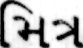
મિત્ર
